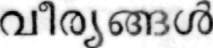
വീര്യങ്ങള്‍
